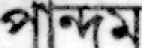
পান্দম
